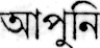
আপুনি
